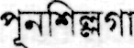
পূনশিল্লগা
